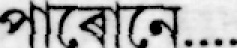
পাৰোনে....
